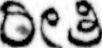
ರೀತಿ
